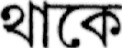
থাকে
